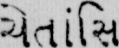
ચેતાંસિ
